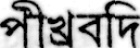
পীখ্রবদি
